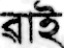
ৱাই
